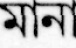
মানা
